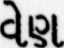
વેણ
